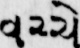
વચ્ચે
